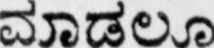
ಮಾಡಲೂ
